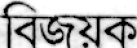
বিজয়ক
